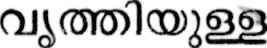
വൃത്തിയുള്ള
